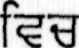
ਵਿਚ
